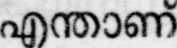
എന്താണ്
